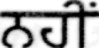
ਨਹੀਂ
